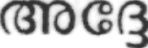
അദ്ദേ
